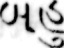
બહુ
